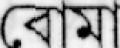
বোমা
